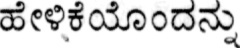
ಹೇಳಿಕೆಯೊಂದನ್ನು
